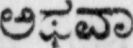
ಅಥವಾ
